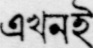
এখনই
